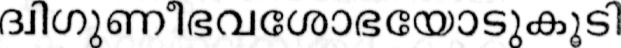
ദ്വിഗുണീഭവശോഭയോടുകൂടി
